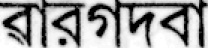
ৱারগদবা
